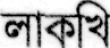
লাকখি
